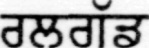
ਰਲਗੱਡ
